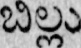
ಬಿಲ್ಲು
